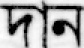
দান
